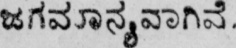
ಜಗಮಾನ್ಯವಾಗಿವೆ.
